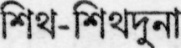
শিথ-শিথদুনা
